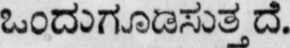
ಒಂದುಗೂಡಸುತ್ತದೆ.
